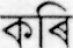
কৰি
